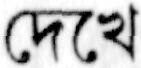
দেখে
